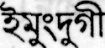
ইমুংদুগী
